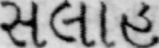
સલાહ
